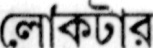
লোকটার
